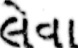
લેવા
